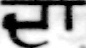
ਦਾ
